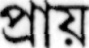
প্রায়
